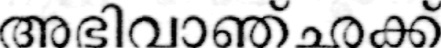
അഭിവാഞ്ഛക്ക്
